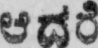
ಆದರೆ
